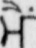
ਮੈਂ
